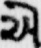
એ
